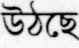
উঠছে
